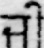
ਜੀ
